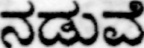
ನಡುವೆ
